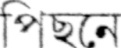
পিছনে
